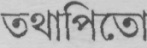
তথাপিতো
